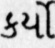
કર્યો
